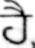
ਹੈ,
